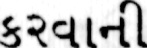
કરવાની
